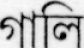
গালি
